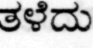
ತಳೆದು
